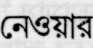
নেওয়ার
